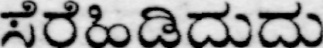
ಸೆರೆಹಿಡಿದುದು
